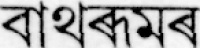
বাথৰূমৰ
